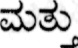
ಮತ್ತು
